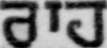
ਰਾਹ
